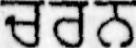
ਚਰਨ
